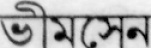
ভীমসেন
